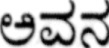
ಅವನ
